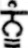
ਨੂੰ
